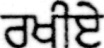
ਰਖੀਏ
